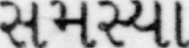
સમસ્યા
